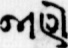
જાણે
